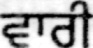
ਵਾਰੀ
